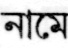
নামে
